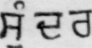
ਸੁੰਦਰ
